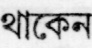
থাকেন
